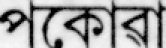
পকোৱা
